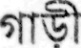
গাড়ী
